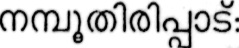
നമ്പൂതിരിപ്പാട്:
